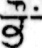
ਭੌਂ
